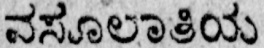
ವಸೂಲಾತಿಯ
